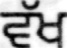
ਵੱਖ
